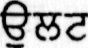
ਉਲਟ
